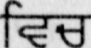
ਵਿਚ
